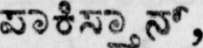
ಪಾಕಿಸ್ತಾನ್,
